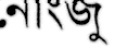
নোংজু
